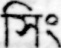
সিং
